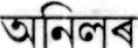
অনিলৰ
